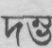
দম্ভ
